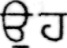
ਉਹ
